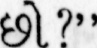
છો?"
